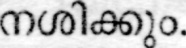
നശിക്കും.
